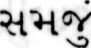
સમજું
